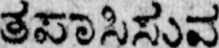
ತಪಾಸಿಸುವ
